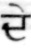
ਦੇ
